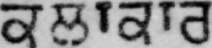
ਕਲਾਕਾਰ
